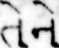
તેને
